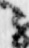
કે
